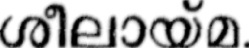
ശീലായ്മ.
